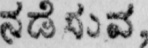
ನಡೆಸುವ,
